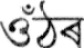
ওঁঠৰ
